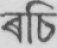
ৰচি
